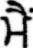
ਮੈਂ
